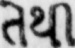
તેથી
